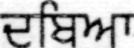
ਦਬਿਆ
